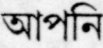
আপনি
